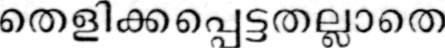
തെളിക്കപ്പെട്ടതല്ലാതെ
